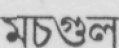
মচগুল
